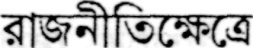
রাজনীতিক্ষেত্রে
